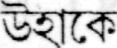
উহাকে
